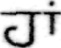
ਹਾਂ
